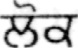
ਲੋਕ
